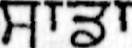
ਸਾਡਾ
